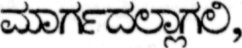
ಮಾರ್ಗದಲ್ಲಾಗಲಿ,
